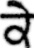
ਕੇ
